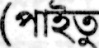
(পাইতু
